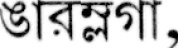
ঙারম্লগা,
